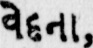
વેદના,
